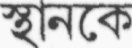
স্থানকে
